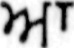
ਆ
